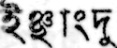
ইঞ্ছাংদু
